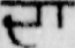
ਦਾ
